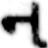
ન
